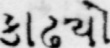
કાઢ્યો
